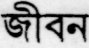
জীবন
